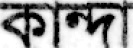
কান্দা
